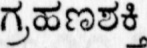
ಗ್ರಹಣಶಕ್ತಿ
